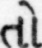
તો
